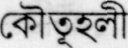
কৌতূহলী
